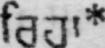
ਰਿਹਾ*
